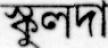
স্কুলদা
